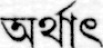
অর্থাৎ
